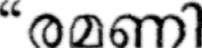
“രമണി
